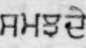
ਸਮਝਦੇ
